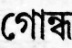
গোন্ধ
